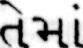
તેમાં
